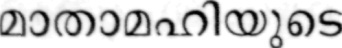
മാതാമഹിയുടെ
